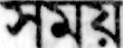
সময়
